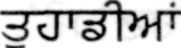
ਤੁਹਾਡੀਆਂ
